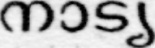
നാട്യ
